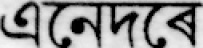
এনেদৰে
